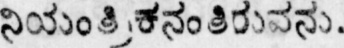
ನಿಯಂತ್ರಿಕನಂತಿರುವನು.
